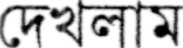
দেখলাম
